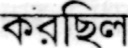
করছিল
